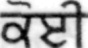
ਕੋਈ
